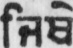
ਜਿਥੇ
